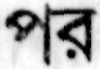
পর
